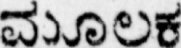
ಮೂಲಕ
